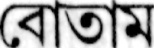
বোতাম
